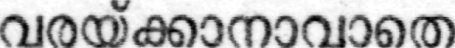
വരയ്ക്കാനാവാതെ
